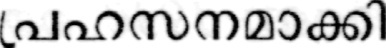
പ്രഹസനമാക്കി
